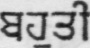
ਬਹੁਤੀ
